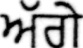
ਅੱਗੇ
